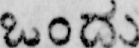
ಒಂದು
